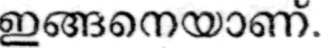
ഇങ്ങനെയാണ്.
